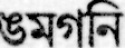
ঙমগনি
